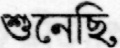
শুনেছি,
